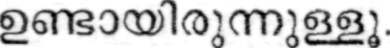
ഉണ്ടായിരുന്നുള്ളൂ.
